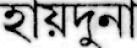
হায়দুনা
